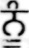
ਨੂੰ
